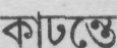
কাঢ়ন্তে
